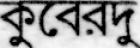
কুবেরদু
